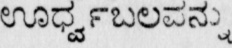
ಊರ್ಧ್ವಬಲವನ್ನು
